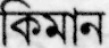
কিমান
